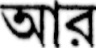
আর
